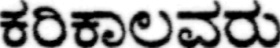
ಕರಿಕಾಲವರು
